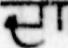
ਦਾ
